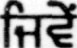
ਜਿਵੇਂ
